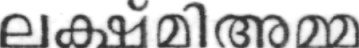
ലക്ഷ്മിഅമ്മ
